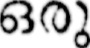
ഒരു
